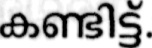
കണ്ടിട്ട്.
